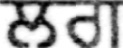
ਲਗ
